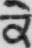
ਕੇ
